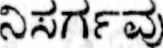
ನಿಸರ್ಗವು
